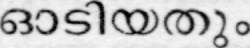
ഓടിയതും
